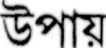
উপায়
